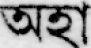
অহা
